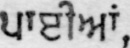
ਪਾਈਆਂ,
